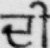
ਦੀ
